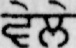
ਵੇਲੇ
